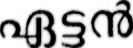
ഏട്ടന്‍
